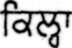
ਕਿਲ੍ਹਾ
